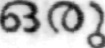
ഒരു
